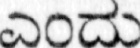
ಎಂದು
